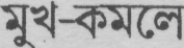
মুখ-কমলে
